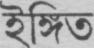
ইঙ্গিত
